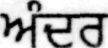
ਅੰਦਰ
